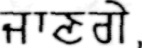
ਜਾਣਗੇ,
